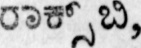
ರಾಕ್ಸ್ ‌ಬಿ,
